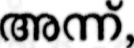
അന്ന്,
